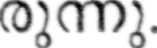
രുന്നു.
